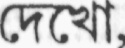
দেখো,
